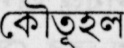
কৌতূহল
